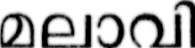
മലാവി
